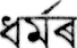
ধর্মৰ
